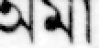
অমা
